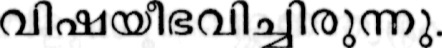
വിഷയീഭവിച്ചിരുന്നു.
